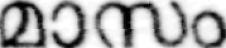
മാസം
